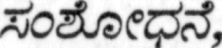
ಸಂಶೋಧನೆ,
